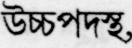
উচ্চপদস্থ,
